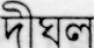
দীঘল
